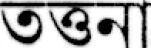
তত্তনা
